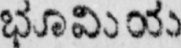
ಭೂಮಿಯ
